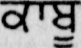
ਕਾਬੂ
